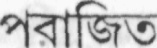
পরাজিত
